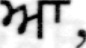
ਆ,
